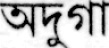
অদুগা
